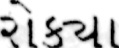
રોક્યા
